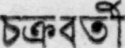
চক্রবর্তী
